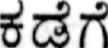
ಕಡೆಗೆ
